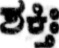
ಶಕ್ತಿಃ
